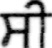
ਸੀ
